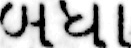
બધા
